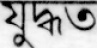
যুদ্ধত
